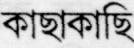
কাছাকাছি
